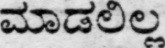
ಮಾಡಲಿಲ್ಲ
